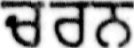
ਚਰਨ
